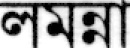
লমন্না
